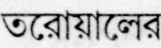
তরোয়ালের
